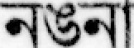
নঙনা
